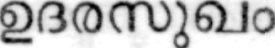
ഉദരസുഖം
